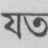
যত
